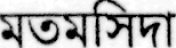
মতমসিদা
